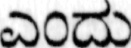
ಎಂದು
